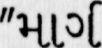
"માર્ગ
